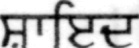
ਸ਼ਾਇਦ
